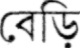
বেড়ি
